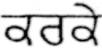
ਕਰਕੇ
